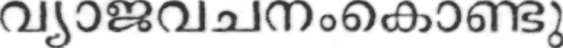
വ്യാജവചനംകൊണ്ടു
